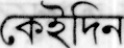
কেইদিন
